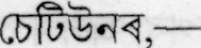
চেটিউনৰ,-
